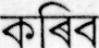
কৰিব
